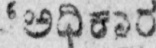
‘ಅಧಿಕಾರ
